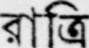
রাত্রি
